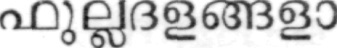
ഫുല്ലദളങ്ങളാ
